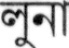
লুনা
